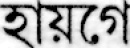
হায়গে
